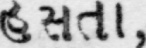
હસતા,
